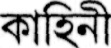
কাহিনী
